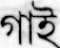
গাই
